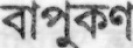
বাপুকণ
